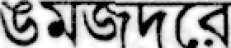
ঙমজদরে
